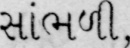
સાંભળી,
